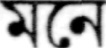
মনে
